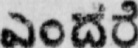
ಎಂದರೆ
